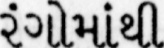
રંગોમાંથી
